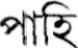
পাহি
